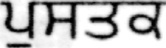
ਪੁਸਤਕ
